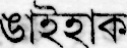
ঙাইহাক
